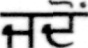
ਜਦੋਂ
